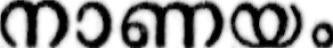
നാണയം
